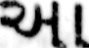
આ
